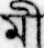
মী
